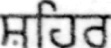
ਸ਼ਹਿਰ
